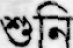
শুনি
